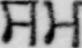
ਸਮ
